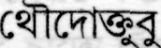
থৌদোক্তুবু
